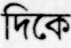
দিকে
